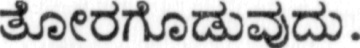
ತೋರಗೊಡುವುದು.
